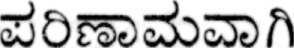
ಪರಿಣಾಮವಾಗಿ
